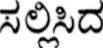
ಸಲ್ಲಿಸಿದ
